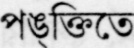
পঙ্ক্তিতে
